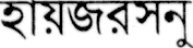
হায়জরসনু
